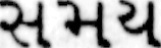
સમય
